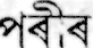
পৰীৰ
